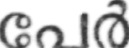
പേര്‍
